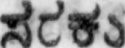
ಸರಕು
